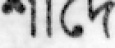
শাদে
